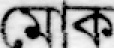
মোক
